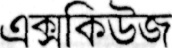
এক্সকিউজ
